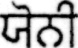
ਯੋਨੀ
